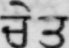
ਚੇਤ
